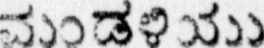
ಮಂಡಳಿಯು
